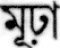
মূঢ়া
